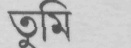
তুমি
